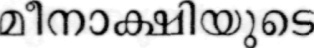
മീനാക്ഷിയുടെ
